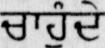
ਚਾਹੁੰਦੇ
